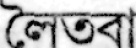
লৈতবা
